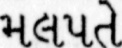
મલપતે
